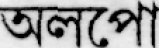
অলপো
